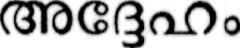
അദ്ദേഹം
